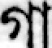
গা
